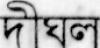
দীঘল
